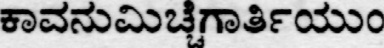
ಕಾವನುಮಿಚ್ಚೆಗಾರ್ತಿಯುಂ
